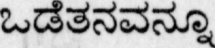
ಒಡೆತನವನ್ನೂ
